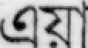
এয়া
